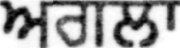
ਅਗਲਾ
